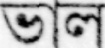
ভাল
